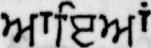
ਆਇਆਂ
